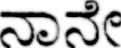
ನಾನೇ
